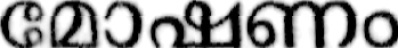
മോഷണം
